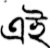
এই
